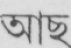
আছ
